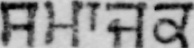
ਸਮਾਜਕ
